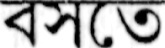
বসতে
